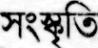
সংস্কৃতি
